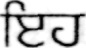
ਇਹ
